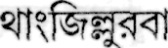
থাংজিল্লুরবা
